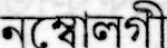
নম্বোলগী
